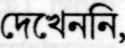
দেখেননি,
